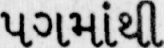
પગમાંથી
